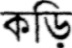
কড়ি
